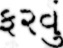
ફરવું
